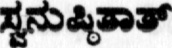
ಸ್ವನುಷ್ಠಿತಾತ್
